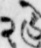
રહે
